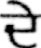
ਦੇ
